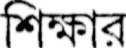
শিক্ষার
